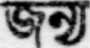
জন্য
